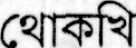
থোকখি
